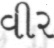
વીર
